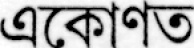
একোণত
